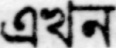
এখন
